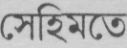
সেহিমতে
